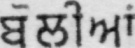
ਬੋਲੀਆਂ
